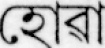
হোৱা
